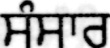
ਸੰਸਾਰ
